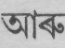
আৰু
